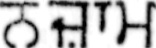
ਨਜ਼ਾਮ
